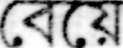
বেয়ে
